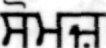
ਸੋਮਜ਼
